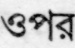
ওপর
